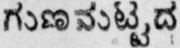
ಗುಣಮಟ್ಟದ
